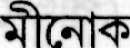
মীনোক
